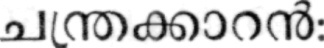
ചന്ത്രക്കാറന്‍:
